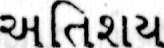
અતિશય
